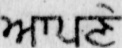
ਆਪਣੇ
